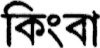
কিংবা
